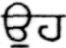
ਉਹ
